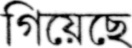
গিয়েছে
